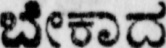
ಬೇಕಾದ
